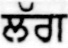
ਲੱਗ
